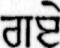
ਗਏ
